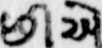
છીએ
